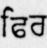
ਫਿਰ
